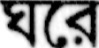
ঘরে
